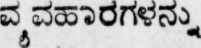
ವ್ಯವಹಾರಗಳನ್ನು
